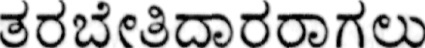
ತರಬೇತಿದಾರರಾಗಲು
